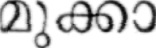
മുക്കാ
